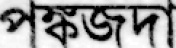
পঙ্কজদা
